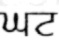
ਘਟ
